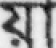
য়া
